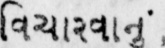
વિચારવાનું,
